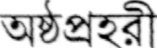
অষ্ঠপ্রহরী
